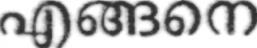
എങ്ങനെ
